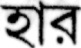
হার
